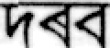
দৰব
